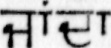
ਜਾਂਦਾ
